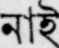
নাই
